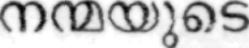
നന്മയുടെ
